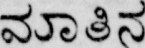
ಮಾತಿನ
